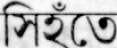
সিহঁতে
